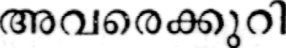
അവരെക്കുറി
